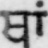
ਥਾਂ
